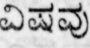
ವಿಷವು
